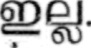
ഇല്ല.
